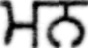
ਮਨ
